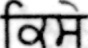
ਕਿਸੇ
